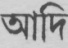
আদি
